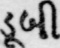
ડૂબી
